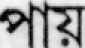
পায়
